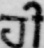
ਹੀ
